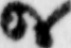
જ
